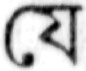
যে
